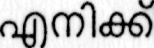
എനിക്ക്
